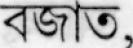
বজাত,
